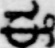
ಈ
